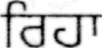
ਰਿਹਾ
